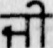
ਜੀ
